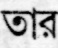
তার
